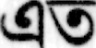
এত
